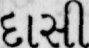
દાસી
